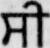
ਸੀ
